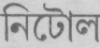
নিটোল
